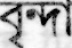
বৃন্দা
